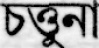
চত্তুনা
